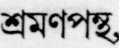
শ্রমণপন্থ,
